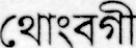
থোংবগী
